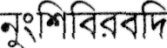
নুংশিবিরবদি
